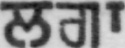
ਲਗਾ
